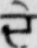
ਦੇ
